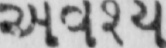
અવશ્ય
